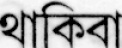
থাকিবা
